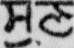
ਸੁਣ
